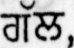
ਗੱਲ,
